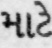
માટે
